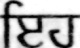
ਇਹ
